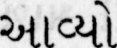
આવ્યો
